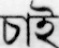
চাই
